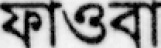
ফাওবা
